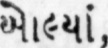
બોલ્યાં,
